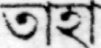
তাহা
